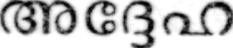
അദ്ദേഹ
